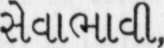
સેવાભાવી,
